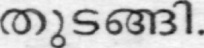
തുടങ്ങി.
